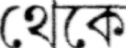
থেকে
